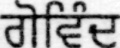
ਗੋਵਿੰਦ
